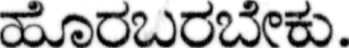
ಹೊರಬರಬೇಕು.
